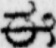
ಈ
